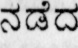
ನಡೆದ
